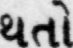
થતો
